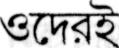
ওদেরই
